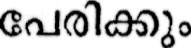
പേരിക്കും
